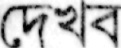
দেখব
